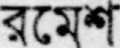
রমেশ
